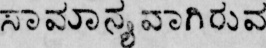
ಸಾಮಾನ್ಯವಾಗಿರುವ
